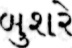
બુશરે
